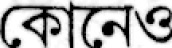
কোনেও
